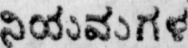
ನಿಯಮಗಳ
